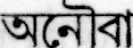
অনৌবা
